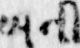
બની
